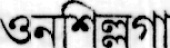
ওনশিল্লগা
